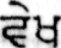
ਵੇਖ
